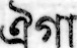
ঐগা
